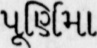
પૂર્ણિમા
